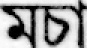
মচা
